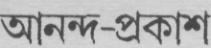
আনন্দ-প্ৰকাশ
